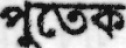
পুতেক
